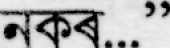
নকৰ..."
